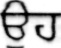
ਉਹ
